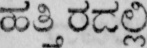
ಹತ್ತಿರದಲ್ಲಿ
